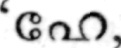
'ഹേ,
